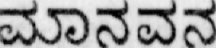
ಮಾನವನ
